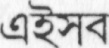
এইসব
